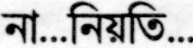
না...নিয়তি...
